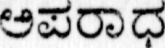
ಅಪರಾಧ
